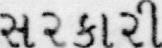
સરકારી
